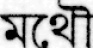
মথৌ
